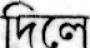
দিলে
